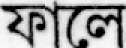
ফালে
